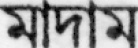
মাদাম
